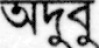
অদুবু
